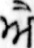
ਐ
